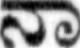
ನಾ
